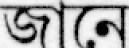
জানে
